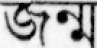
জন্ম
